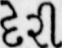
દેરી
